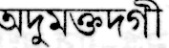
অদুমক্তদগী
